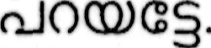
പറയട്ടേ.
